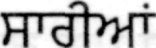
ਸਾਰੀਆਂ
